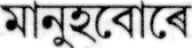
মানুহবোৰে
